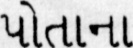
પોતાના
